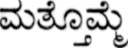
ಮತ್ತೊಮ್ಮೆ
